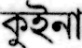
কুইনা
